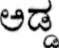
ಅಡ್ಡ
